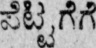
ಪೆಟ್ಟಿಗೆಗೆ
